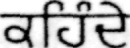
ਕਹਿੰਦੇ
